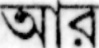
আর
